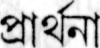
প্রার্থনা
